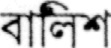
বালিশ
